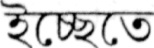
ইচ্ছেতে
